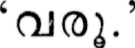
‘വരൂ.’
